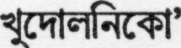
খুদোলনিকো’
